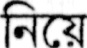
নিয়ে
